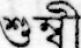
শুম্বী
